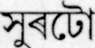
সুৰটো
